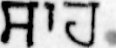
ਸਾਹ
